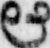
ಆ
